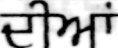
ਦੀਆਂ
